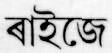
ৰাইজে
